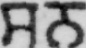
ਸਨ
